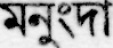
মনুংদা
